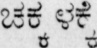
ಚಕ್ಕಳಕ್ಕೆ
